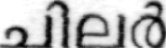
ചിലര്‍
